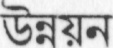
উন্নয়ন
